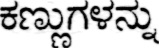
ಕಣ್ಣುಗಳನ್ನು
